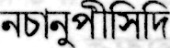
নচানুপীসিদি
